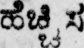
ಹೆಚ್ಚಿಸ
